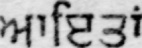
ਆਇਤਾਂ
